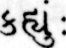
કહ્યું:
